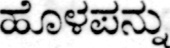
ಹೊಳಪನ್ನು
